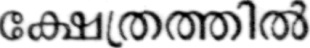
ക്ഷേത്രത്തില്‍
